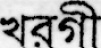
খরগী
